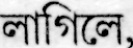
লাগিলে,
